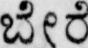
ಬೇರೆ
